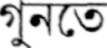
গুনতে
